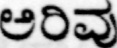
ಅರಿವು
